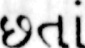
છતાં
